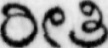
ರೀತಿ
